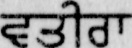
ਵਤੀਰਾ
